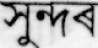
সুন্দৰ
